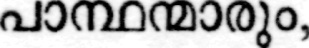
പാന്ഥന്മാരും,
